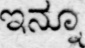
ಇನ್ನೂ
